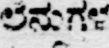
ಲೆನ್ಸುಗಳ
